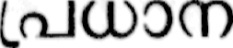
പ്രധാന
